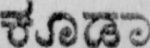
ಕೂಡಾ
